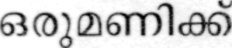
ഒരുമണിക്ക്
